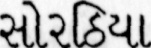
સોરઠિયા
